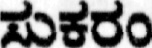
ಸುಕರಂ
